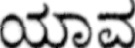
ಯಾವ
